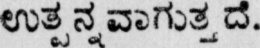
ಉತ್ಪನ್ನವಾಗುತ್ತದೆ.
